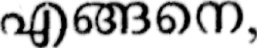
എങ്ങനെ,
